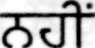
ਨਹੀਂ
